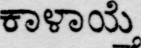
ಕಾಳಾಯ್ತೆ
